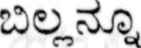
ಬಿಲ್ಲನ್ನೂ
